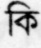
কি
